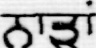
ਨਾੜਾਂ
